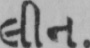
લીન.
